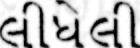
લીધેલી
